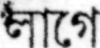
লাগে
